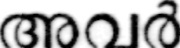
അവര്‍
